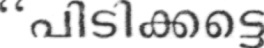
"പിടിക്കട്ടെ
